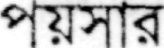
পয়সার
